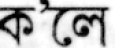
ক'লে
